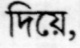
দিয়ে,
